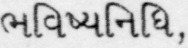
ભવિષ્યનિધિ,
